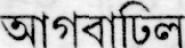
আগবাঢ়িল
